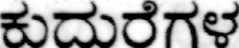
ಕುದುರೆಗಳ
